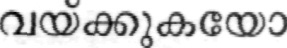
വയ്ക്കുകയോ
